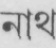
নাথ
